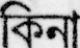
কিনা
